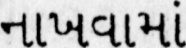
નાખવામાં
